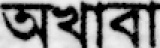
অখাবা
